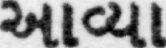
આવ્યા
